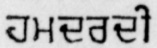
ਹਮਦਰਦੀ
